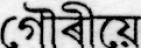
গৌৰীয়ে
